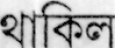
থাকিল
